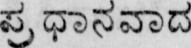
ಪ್ರಧಾನವಾದ
